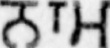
ਨਾਮ
